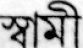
স্বামী
